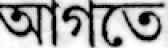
আগতে
